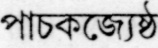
পাচকজ্যেষ্ঠ
